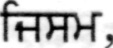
ਜਿਸਮ,
